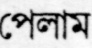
পেলাম
